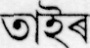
তাইৰ
